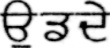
ਉਡਦੇ
